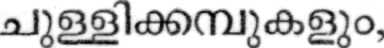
ചുള്ളിക്കമ്പുകളും,
